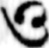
ও
